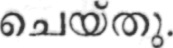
ചെയ്തു.
